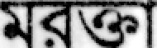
মরক্তা
